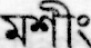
মশীং
